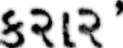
કરાર"
